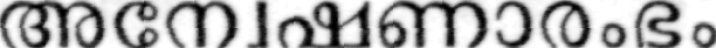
അന്വേഷണാരാംഭം
